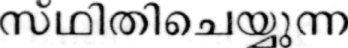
സ്ഥിതിചെയ്യുന്ന
